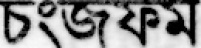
চংজফম
